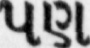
પણ
